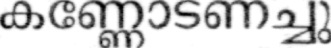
കണ്ണോടണച്ചു
